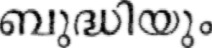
ബുദ്ധിയും
